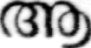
ആ
